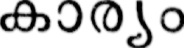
കാര്യം
